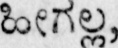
ಹೀಗಲ್ಲ,
